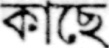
কাছে
